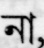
না,
